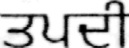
ਤਪਦੀ
